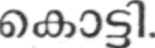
കൊട്ടി.
